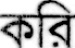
করি
